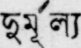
দুর্মূল্য
